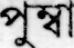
পুম্বা
